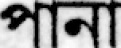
পানা
